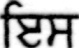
ਇਸ
